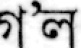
গ'ল
